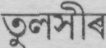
তুলসীৰ
